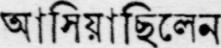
আসিয়াছিলেন
